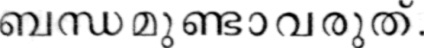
ബന്ധമുണ്ടാവരുത്.
